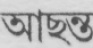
আছন্ত
